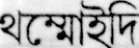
থম্মোইদি
